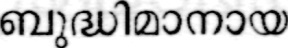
ബുദ്ധിമാനായ
